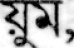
য়ুম,
